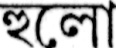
হুলো
